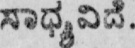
ಸಾಧ್ಯವಿದೆ.
